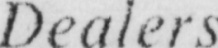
Dealers
